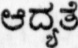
ಆದ್ಯತೆ
